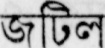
জটিল
